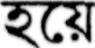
হয়ে
